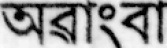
অৱাংবা
